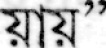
য়ায়”
